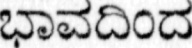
ಭಾವದಿಂದ
